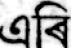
এৰি
